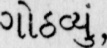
ગોઠવ્યું,
